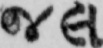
જલ
